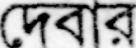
দেবার
